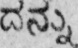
ದನ್ನು
